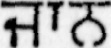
ਜਾਨ
